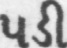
પડી
